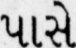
પાસે
